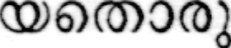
യതൊരു
